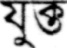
যুক্ত
